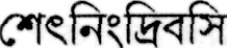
শেৎনিংদ্রিবসি
